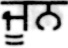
ਜੂਨ
